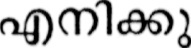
എനിക്കു
